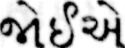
જોઈએ
